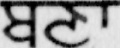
ਬਣਾ
